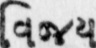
વિજય
